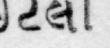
ઈટલી
